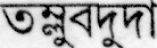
তম্লুবদুদা
